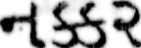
નક્કર
